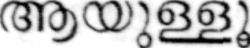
ആയുള്ളൂ
